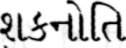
શકનોતિ
